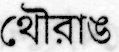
থৌরাঙ
